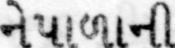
નેપાળાની
